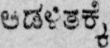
ಅಡಳಿತಕ್ಕೆ
